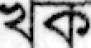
খক
